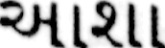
આશા
